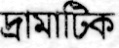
দ্রামাটিক
